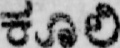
ಕೂಲಿ
